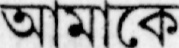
আমাকে
